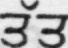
ਤੱਤ
